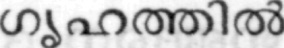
ഗൃഹത്തില്‍
